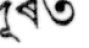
দূৰত
